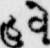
હવે
